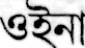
ওইনা
